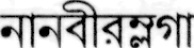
নানবীরম্লগা
